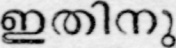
ഇതിനു
